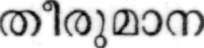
തീരുമാന
